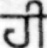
ਹੀ
